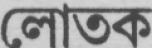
লোতক
